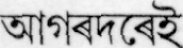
আগৰদৰেই
